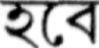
হবে
